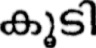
കൂടി
